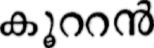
കൂററന്‍
